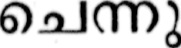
ചെന്നു
